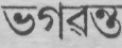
ভগৱন্ত
